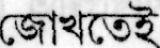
জোখতেই
